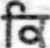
ਕਿ
